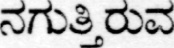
ನಗುತ್ತಿರುವ
